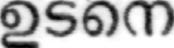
ഉടനെ
